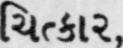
ચિત્કાર,
